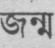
জন্ম
